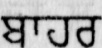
ਬਾਹਰ
